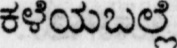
ಕಳೆಯಬಲ್ಲೆ
